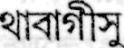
থাবাগীসু
